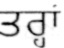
ਤਰ੍ਹਾਂ
